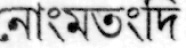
নোংমতংদি
